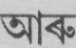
আৰু
